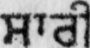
ਸਾਰੀ
